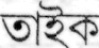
তাইক
